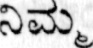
ನಿಮ್ಮ
